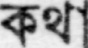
কথা
